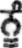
ਨੂੰ
